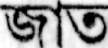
জাত
